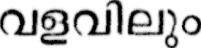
വളവിലും
